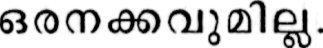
ഒരനക്കവുമില്ല.
